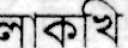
লাকখি
